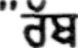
''ਰੱਬ
